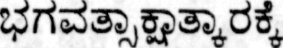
ಭಗವತ್ಸಾಕ್ಷಾತ್ಕಾರಕ್ಕೆ
